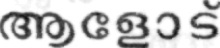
ആളോട്
